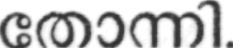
തോന്നി.
